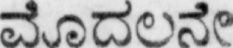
ಮೊದಲನೇ
